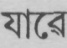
যাৱে
